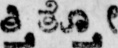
ತ್ತಿತ್ತೋ
